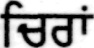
ਚਿਰਾਂ
